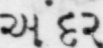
અંદર
